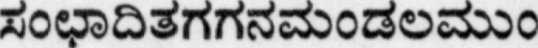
ಸಂಛಾದಿತಗಗನಮಂಡಲಮುಂ
